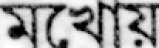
মখোয়
